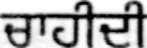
ਚਾਹੀਦੀ
